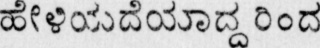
ಹೇಳಿಯದೆಯಾದ್ದರಿಂದ
